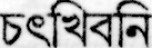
চৎখ্রিবনি
